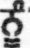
ਨੂੰ
